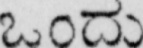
ಒಂದು
